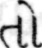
તો
